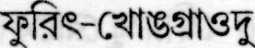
ফুরিৎ-খোঙগ্রাওদু
